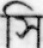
সি
